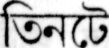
তিনটে
